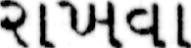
રાખવા
